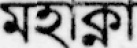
মহাক্না
